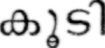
കൂടി
